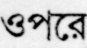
ওপরে
